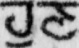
ਹੁਣ
